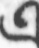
এ
